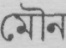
মৌন
